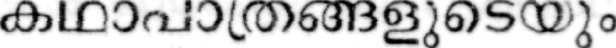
കഥാപാത്രങ്ങളുടെയും
